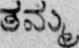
ತಮ್ಮ
